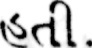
હતી.
